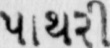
પાથરી
